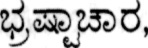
ಭ್ರಷ್ಟಾಚಾರ,
